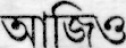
আজিও
